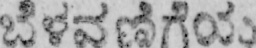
ಬೆಳವಣಿಗೆಯ
